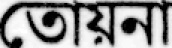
তোয়না
